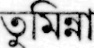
তুমিন্না
